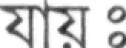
যায়ঃ
